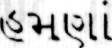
હમણાં
